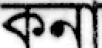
কনা
